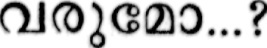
വരുമോ...?
